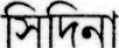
সিদিনা
